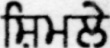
ਸ਼ਿਮਲੇ
